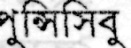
পুন্সিসিবু
